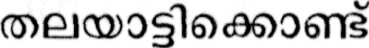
തലയാട്ടിക്കൊണ്ട്
